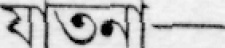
যাতনা-
